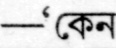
–‘কেন
